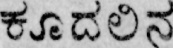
ಕೂದಲಿನ
